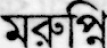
মরুপ্নি
